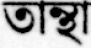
তান্থা
